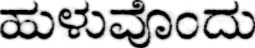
ಹುಳುವೊಂದು
